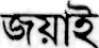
জয়াই
